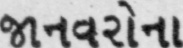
જાનવરોના
